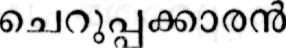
ചെറുപ്പക്കാരന്‍
